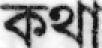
কথা
